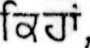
ਕਿਹਾਂ,
